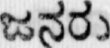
ಜನರು
